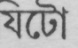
যিটো
